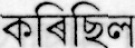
কৰিছিল
